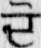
ਦੋ
